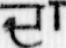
ਦਾ
